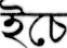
ইচে
